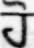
ਹੋ
